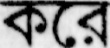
করে
